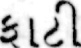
ફાટી
